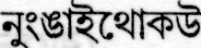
নুংঙাইথোকউ
